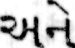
અને
